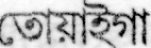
তোয়াইগা
